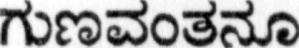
ಗುಣವಂತನೂ
